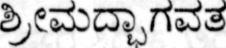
ಶ್ರೀಮದ್ಭಾಗವತ
